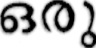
ഒരു
